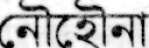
নৌহৌনা
